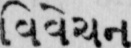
વિવેચન
